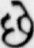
છે
